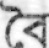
বৈ
